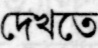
দেখতে
